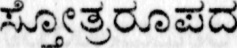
ಸ್ತೋತ್ರರೂಪದ
